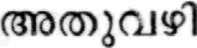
അതുവഴി
